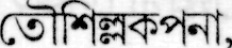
তৌশিল্লকপনা,
